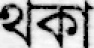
থকা
